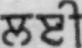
ਲਈ
